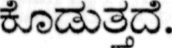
ಕೊಡುತ್ತದೆ.
